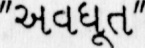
"અવધૂત"
